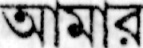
আমার
